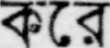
করে
